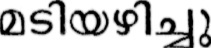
മടിയഴിച്ചു
